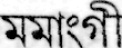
মমাংগী
